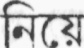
নিয়ে
